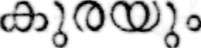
കുരയും
